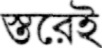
স্তরেই
